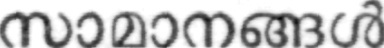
സാമാനങ്ങള്‍
